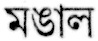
মঙাল
